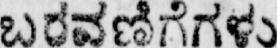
ಬರವಣಿಗೆಗಳು
